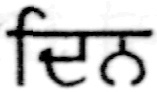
ਦਿਨ
